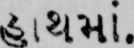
હાથમાં.
